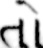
તો
